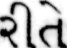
રીતે
